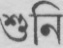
শুনি
